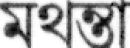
মথন্তা
